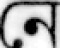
নে
